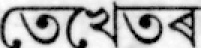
তেখেতৰ
